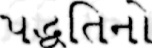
પદ્ધતિનો
